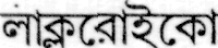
লাক্লরোইকো
